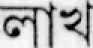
লাখ
